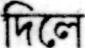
দিলে
